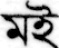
মই
